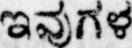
ಇವುಗಳ
